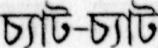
চ্যাট-চ্যাট
